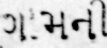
ગામની
